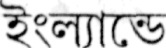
ইংল্যান্ডে
